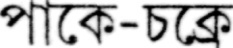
পাকে-চক্রে
